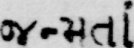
જન્મતાં
